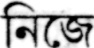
নিজে
